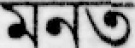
মনত
